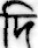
দি
